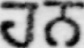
ਹਨ
